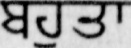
ਬਹੁਤਾ
